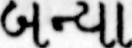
બન્યા
